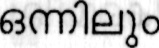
ഒന്നിലും
